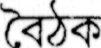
বৈঠক
